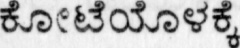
ಕೋಟೆಯೊಳಕ್ಕೆ
